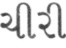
ચીરી
